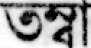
তম্বা
